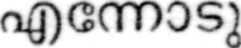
എന്നോടു
